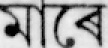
মাৰে
